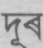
দূৰ
